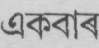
একবাৰ
